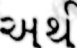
અર્થ
